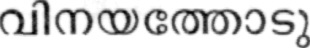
വിനയത്തോടു
